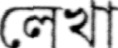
লেখা
